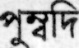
পুম্বদি
